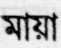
মায়া
